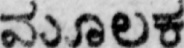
ಮೂಲಕ
